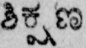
ಶಿಕ್ಷಣ
